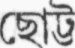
ছোট্ট
